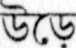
উড়ে
